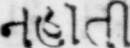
નહોતી
